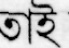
তাই
